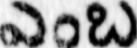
ಎಂಬ
